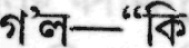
গ'ল-"কি
